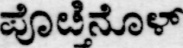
ಪೊೞ್ತೆನೊಳ್
